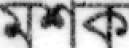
মশক
